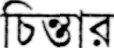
চিন্তার
